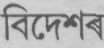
বিদেশৰ
